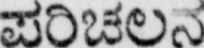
ಪರಿಚಲನ
